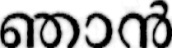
ഞാന്‍
